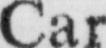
Car
